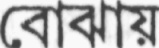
বোঝায়
